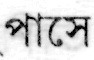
পাসে
